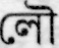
লৌ
